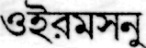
ওইরমসনু
